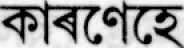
কাৰণেহে
